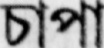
চাপা
